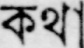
কথা
